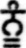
ਨੂੰ
